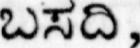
ಬಸದಿ,
